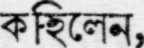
কহিলেন,
